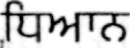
ਧਿਆਨ
